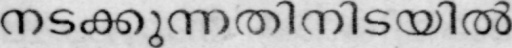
നടക്കുന്നതിനിടയില്‍
